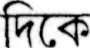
দিকে
